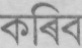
কৰিব
